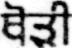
ਥੋੜੀ
